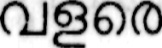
വളരെ
